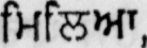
ਮਿਲਿਆ,
